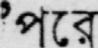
'পরে
